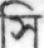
সি
